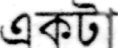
একটা
